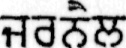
ਜਰਨੈਲ
